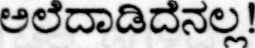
ಅಲೆದಾಡಿದೆನಲ್ಲ!
